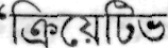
‘ক্রিয়েটিভ
